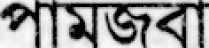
পামজবা
